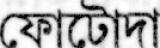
ফোটোদা
